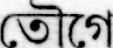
তৌগে
